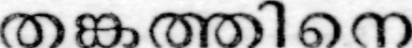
തങ്കത്തിനെ
